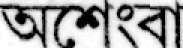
অশেংবা
